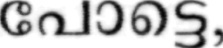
പോട്ടെ,
